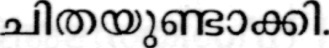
ചിതയുണ്ടാക്കി.
